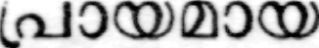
പ്രായമായ
